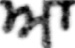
ਆ
